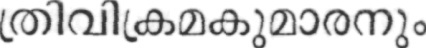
ത്രിവിക്രമകുമാരനും
